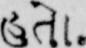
હતો.
